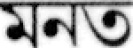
মনত
